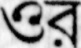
ওর
